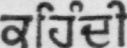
ਕਹਿੰਦੀ
